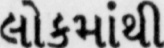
લોકમાંથી
